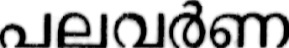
പലവര്‍ണ
